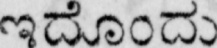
ಇದೊಂದು
